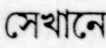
সেখানে
